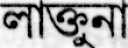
লাক্তুনা
